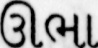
ઊભા
